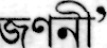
জণনী’
